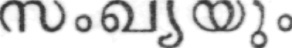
സംഖ്യയും
